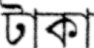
টাকা
